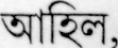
আহিল,
